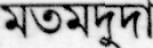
মতমদুদা
